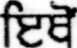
ਇਥੋਂ
